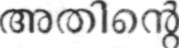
അതിന്റെ
